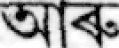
আৰু
